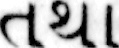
તથા
